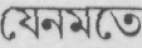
যেনমতে
